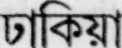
ঢাকিয়া
